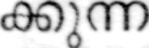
ക്കുന്ന
